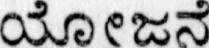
ಯೋಜನೆ
